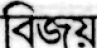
বিজয়
